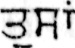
ਤੁਸਾਂ
